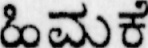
ಹಿಮಕೆ
